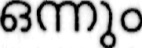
ഒന്നും
